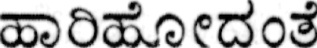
ಹಾರಿಹೋದಂತೆ
